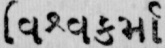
વિશ્વકર્મા
